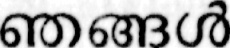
ഞങ്ങള്‍
